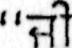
''ਜੀ
